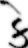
કે
